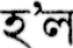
হ'ল
